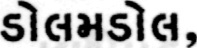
ડોલમડોલ,
